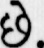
છે.
